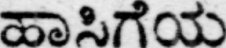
ಹಾಸಿಗೆಯ
